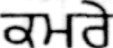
ਕਮਰੇ
